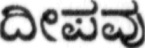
ದೀಪವು
